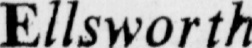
Ellsworth
